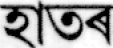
হাতৰ
